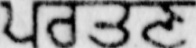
ਪਰਤਣ
